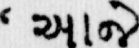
'આજે
